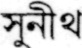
সুনীথ
